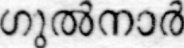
ഗുല്‍നാര്‍
